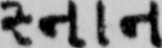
સ્નાન
